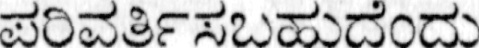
ಪರಿವರ್ತಿಸಬಹುದೆಂದು
